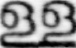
ള്ള
